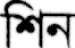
শিন
